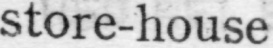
store-house
